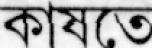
কাষতে
